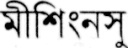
মীশিংনসু
